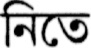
নিতে
